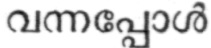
വന്നപ്പോള്‍
